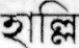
হাল্লি
